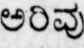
ಅರಿವು
